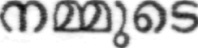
നമ്മുടെ
